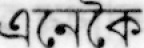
এনেকৈ
